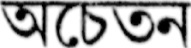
অচেতন
